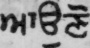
ਆਉਣੋ
